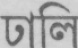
ঢালি
